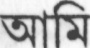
আমি
